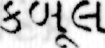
કબૂલ
